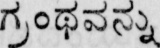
ಗ್ರಂಥವನ್ನು
